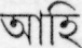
আহি
